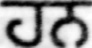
ਹਨ
